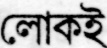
লোকই
